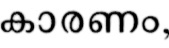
കാരണം,
